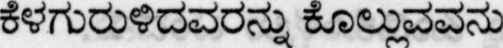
ಕೆಳಗುರುಳಿದವರನ್ನುಕೊಲ್ಲುವನು
